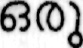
ഒരു
